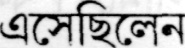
এসেছিলেন
